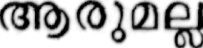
ആരുമല്ല
